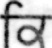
ਕਿ
